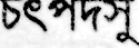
চৎপদসু
